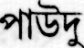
পাউদু
